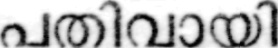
പതിവായി
